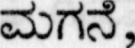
ಮಗನೆ,
